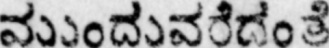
ಮುಂದುವರೆದಂತೆ
